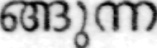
ങ്ങുന്ന
